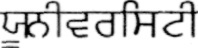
ਯੂਨੀਵਰਸਿਟੀ
